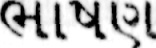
ભાષણ
